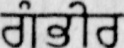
ਗੰਭੀਰ
